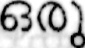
ഒരു
